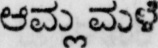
ಆಮ್ಲಮಳೆ
